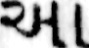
આ
